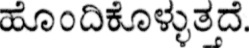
ಹೊಂದಿಕೊಳ್ಳುತ್ತದೆ.
